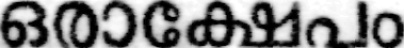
ഒരാക്ഷേപം
